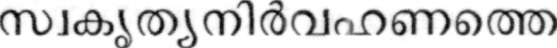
സ്വകൃത്യനിര്‍വഹണത്തെ
